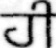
ਹੀ
